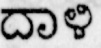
ದಾಳಿ
